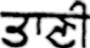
ਤਾਣੀ
